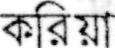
করিয়া
